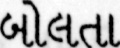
બોલતા
